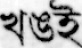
খঙই
